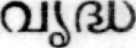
വൃദ്ധ
